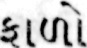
ફાળો
